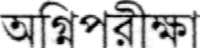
অগ্নিপরীক্ষা
